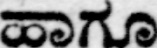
ಹಾಗೂ
